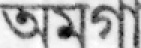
অমগা
